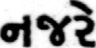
નજરે
